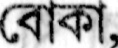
বোকা,
